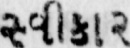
સ્વીકાર
